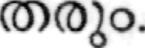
തരും.
